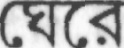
ঘেরে
